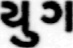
યુગ
